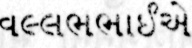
વલ્લભભાઈએ
